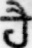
ਹੈ
